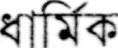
ধার্মিক
